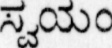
ಸ್ವಯಂ
